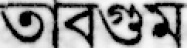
তাবগুম
